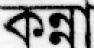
কন্না
